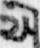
એ
